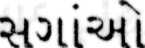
સગાંઓ
